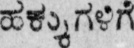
ಹಕ್ಕುಗಳಿಗೆ
